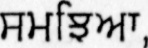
ਸਮਝਿਆ,
